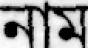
নাম
